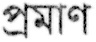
প্রমাণ
